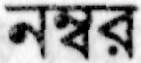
নম্বর
